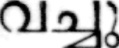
വച്ചു
